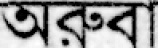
অরুবা
